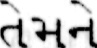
હતા.તેમને
